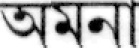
অমনা
